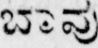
ಬಾವು
